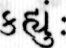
કહ્યુંઃ
